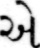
એ
